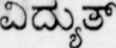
ವಿದ್ಯುತ್
